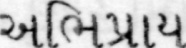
અભિપ્રાય
